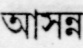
আসন্ন
